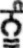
ਨੂੰ
